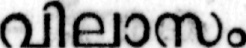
വിലാസം
